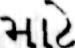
માટે
